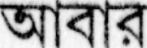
আবার
